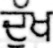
ਦੁੱਖ
